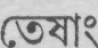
তেষাং
